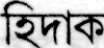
হিদাক
